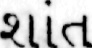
શાંત
